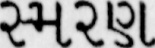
સ્મરણ
